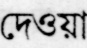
দেওয়া
